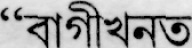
"বাগীখনত
